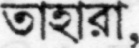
তাহারা,
